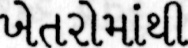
ખેતરોમાંથી
